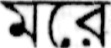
মরে
